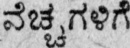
ವೆಚ್ಚಗಳಿಗೆ
